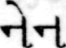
નેન
